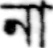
না
